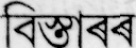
বিস্তাৰৰ
